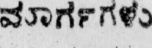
ಮಾರ್ಗಗಳು
